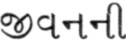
જીવનની
